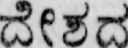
ದೇಶದ
